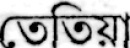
তেতিয়া
